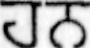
ਹਨ
